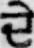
ਦੇ
